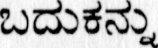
ಬದುಕನ್ನು
